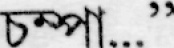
চম্পা..."
